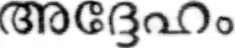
അദ്ദേഹം
